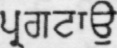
ਪ੍ਰਗਟਾਉ
